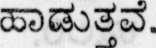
ಹಾಡುತ್ತವೆ.
